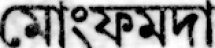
মোংফমদা
